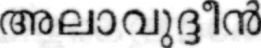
അലാവുദ്ദീന്‍
